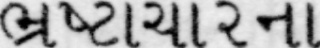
ભ્રષ્ટાચારના
